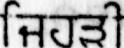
ਜਿਹੜੀ
